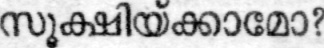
സൂക്ഷിയ്ക്കാമോ?
